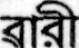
ৱারী
